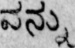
ವನ್ನು
